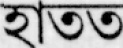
হাতত
